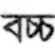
বচ্চ
